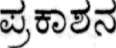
ಪ್ರಕಾಶನ
